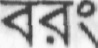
বরং
